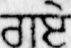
ਗਏ
